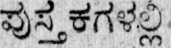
ಪುಸ್ತಕಗಳಲ್ಲಿ
